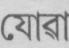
যোৱা
